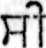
ਸੀ
